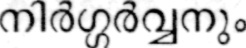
നിര്‍ഗ്ഗര്‍വ്വനും
